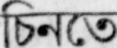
চিনতে
